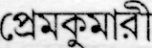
প্রেমকুমারী
